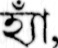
হ্যাঁ,
